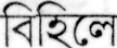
বিহিলে
